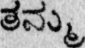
ತಮ್ಮ
